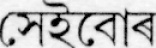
সেইবোৰ
